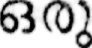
ഒരു
